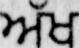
ਅੱਖ
